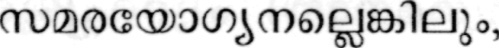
സമരയോഗ്യനല്ലെങ്കിലും,
